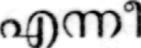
എന്നീ
